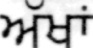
ਅੱਖਾਂ
